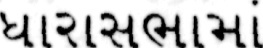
ધારાસભામાં
